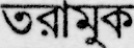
তরামুক
